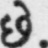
છે.
